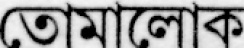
তোমালোক
